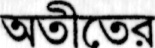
অতীতের
